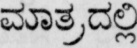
ಮಾತ್ರದಲ್ಲಿ
